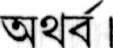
অথর্ব।
